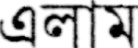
এলাম
